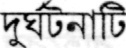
দুর্ঘটনাটি
